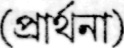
(প্রার্থনা)
